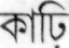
কাঢ়ি
